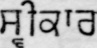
ਸ੍ਵੀਕਾਰ
